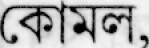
কোমল,
